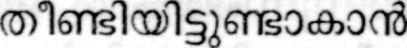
തീണ്ടിയിട്ടുണ്ടാകാന്‍
